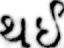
થઈ
